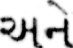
અને
